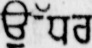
ਉੱਧਰ
